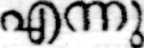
എന്നു
